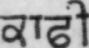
ਕਾਫੀ
